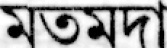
মতমদা
